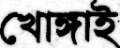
খোঙ্গাই
